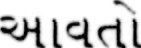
આવતો
